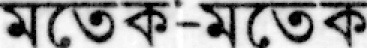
মতেক-মতেক
